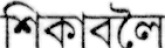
শিকাবলৈ
